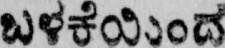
ಬಳಕೆಯಿಂದ
